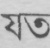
যত
